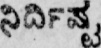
ನಿರ್ದಿಷ್ಟ
